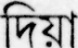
দিয়া
